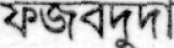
ফজবদুদা
